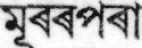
মূৰৰপৰা
